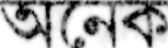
অনেক
